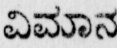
ವಿಮಾನ
